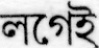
লগেই
